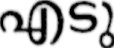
എടു
